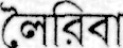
লৈরিবা
